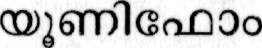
യൂണിഫോം
